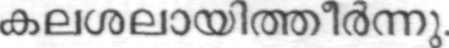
കലശലായിത്തീര്‍ന്നു.
